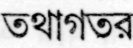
তথাগতর
